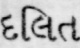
દલિત
